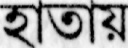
হাতায়
